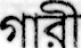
গারী
